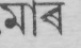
মোৰ
